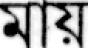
মায়
